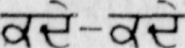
ਕਦੇ-ਕਦੇ
